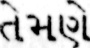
તેમણે
